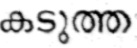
കടുത്ത
